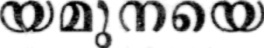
യമുനയെ
